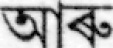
আৰু
